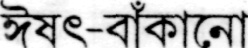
ঈষৎ-বাঁকানো
